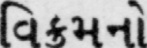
વિક્રમનો
